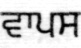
ਵਾਪਸ
